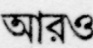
আরও
